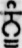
ਨੂੰ
